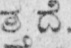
ತ್ತದೆ.
